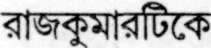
রাজকুমারটিকে
